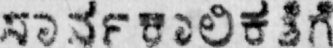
ಸಾರ್ವಕಾಲಿಕತೆಗೆ
